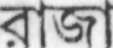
রাজা
